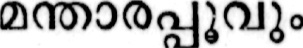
മന്താരപ്പൂവും
